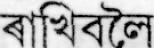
ৰাখিবলৈ
